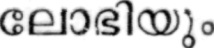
ലോഭിയും
